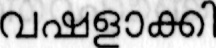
വഷളാക്കി
